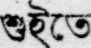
শুইতে
